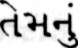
તેમનું
